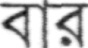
বার
